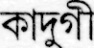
কাদুগী
